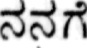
ನನಗೆ
